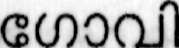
ഗോവി
